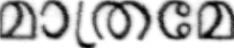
മാത്രമേ
